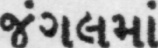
જંગલમાં
